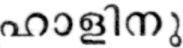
ഹാളിനു
